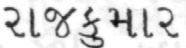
રાજકુમાર
